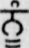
ਨੂੰ
